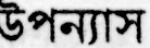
উপন্যাস
